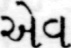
એવ
